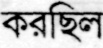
করছিল
